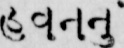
હવનનું
